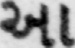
આ
